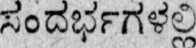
ಸಂದರ್ಭಗಳಲ್ಲಿ
